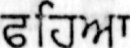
ਫਹਿਆ
